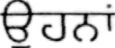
ਉਹਨਾਂ
